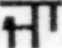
ਜਾ
